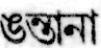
ঙন্তানা
